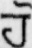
ਹੋ
